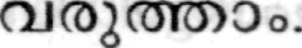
വരുത്താം.
